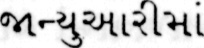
જાન્યુઆરીમાં
